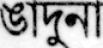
ঙাদুনা
